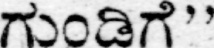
ಗುಂಡಿಗೆ"
